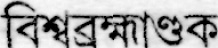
বিশ্বব্রহ্মাণ্ডক
